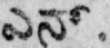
ಎನ್.
